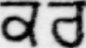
ਕਰ
